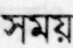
সময়
